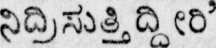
ನಿದ್ರಿಸುತ್ತಿದ್ದೀರಿ’
